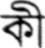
কী
